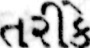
તરીકે
